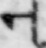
ન
